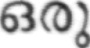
ഒരു
